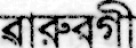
ৱারুবগী
